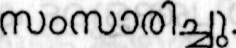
സംസാരിച്ചു.
